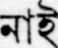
নাই
